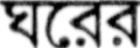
ঘরের
